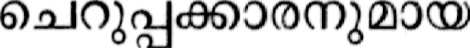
ചെറുപ്പക്കാരനുമായ
